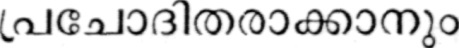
പ്രചോദിതരാക്കാനും
